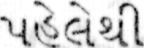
પહેલેથી
